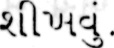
શીખવું.
